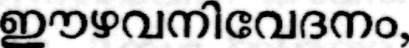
ഈഴവനിവേദനം,
